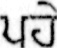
ਪਹੇ
